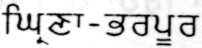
ਘ੍ਰਿਣਾ-ਭਰਪੂਰ
